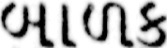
બાળક
